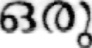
ഒരു
